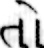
તો
